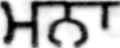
ਮਨਾ
